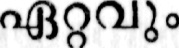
ഏറ്റവും
